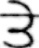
ਤੇ
